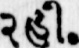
રહી.
